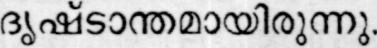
ദൃഷ്ടാന്തമായിരുന്നു.
